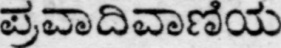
ಪ್ರವಾದಿವಾಣಿಯ
